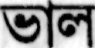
ভাল
